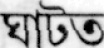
ঘাটত
